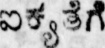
ಐಕ್ಯತೆಗೆ
